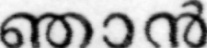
ഞാന്‍
